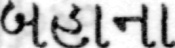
બહાના
